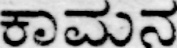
ಕಾಮನ
